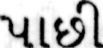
પાછી
